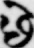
છે
